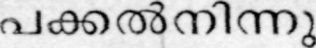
പക്കല്‍നിന്നു
